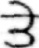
ਤੇ
